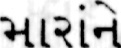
મારાંને
